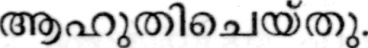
ആഹുതിചെയ്തു.
